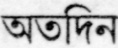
অতদিন
